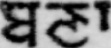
ਬਣਾ
